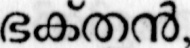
ഭക്തന്‍,
